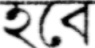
হবে
